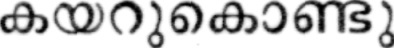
കയറുകൊണ്ടു
